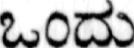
ಒಂದು
